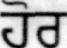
ਹੋਰ
